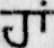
ਹਾਂ
